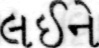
લઈને
